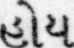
હોય
